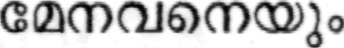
മേനവനെയും
